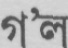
গ'ল
